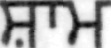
ਸ਼ਾਮ
